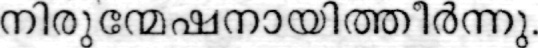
നിരുന്മേഷനായിത്തീര്‍ന്നു.
